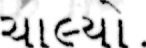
ચાલ્યો.
